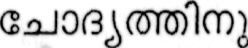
ചോദ്യത്തിനു
